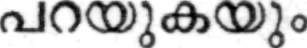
പറയുകയും
